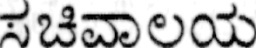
ಸಚಿವಾಲಯ
